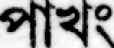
পাখং
